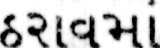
ઠરાવમાં
